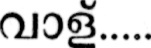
വാള്.....
